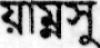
য়াম্লসু
